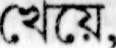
খেয়ে,
